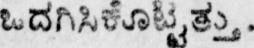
ಒದಗಿಸಿಕೊಟ್ಟಿತ್ತು.
